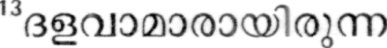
13ദളവാമാരായിരുന്ന
